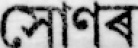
সোণৰ
